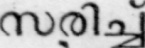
സരിച്ച്
